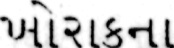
ખોરાકના
